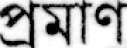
প্রমাণ
